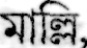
মাল্লি,
